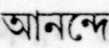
আনন্দে
